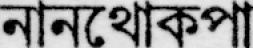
নানথোকপা
